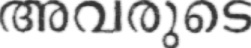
അവരുടെ
